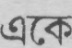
একে
